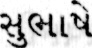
સુભાષે
